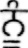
ਨੂੰ
